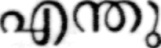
എന്തു
